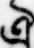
ঐ
